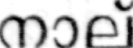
നാല്
